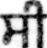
ਸੀ
